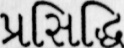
પ્રસિદ્ધિ
